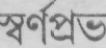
স্বৰ্ণপ্ৰভ
